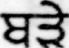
ਬੜੇ
